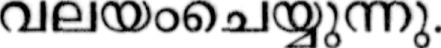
വലയംചെയ്യുന്നു.
